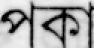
পকা
